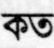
কত
